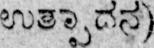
ಉತ್ಪಾದನ)
